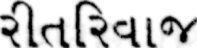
રીતરિવાજ
